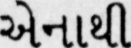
એનાથી
